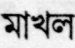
মাখল
